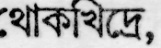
থোকখিদ্রে,
